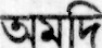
অমদি
